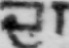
ਦਾ
